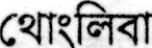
থোংলিবা
